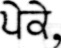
ਪੇਕੇ,
